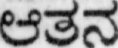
ಆತನ
